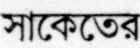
সাকেতের
